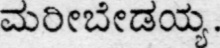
ಮರೀಬೇಡಯ್ಯ.
